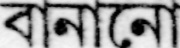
বানানো
